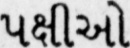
પક્ષીઓ
